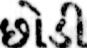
છોડી
